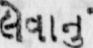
લેવાનું
